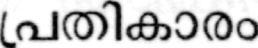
പ്രതികാരം
